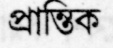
প্রান্তিক
